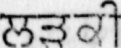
ਲੜਕੀ
